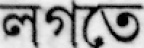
লগতে
